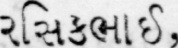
રસિકભાઈ,
